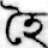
হৈ
